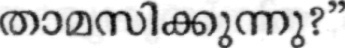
താമസിക്കുന്നു?"
